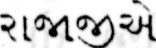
રાજાજીએ
